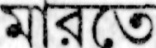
মারতে
